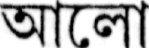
আলো
